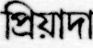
প্রিয়াদা
